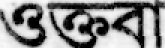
ওক্তবা
